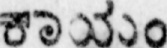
ಕಾಯಂ
